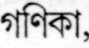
গণিকা,
